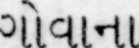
ગોવાના
